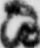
ಡಿ
